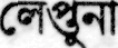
লেপ্তুনা
